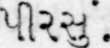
પીરસું.
